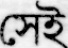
সেই
